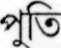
পুতি
